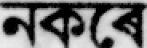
নকৰে
